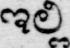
ಇಲ್ಲಿ
